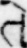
તે
